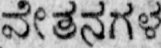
ವೇತನಗಳ
